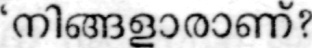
‘നിങ്ങളാരാണ്?
